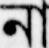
না
